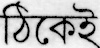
ঠিকেই
